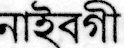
নাইবগী
